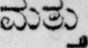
ಮತ್ತು
